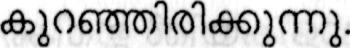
കുറഞ്ഞിരിക്കുന്നു.
